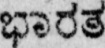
ಭಾರತ
